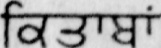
ਕਿਤਾਬਾਂ
